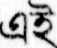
এই
